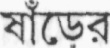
ষাঁড়ের
